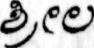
ಶ್ರೀಲ
